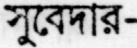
সুবেদার-
